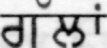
ਗੱਲਾਂ
